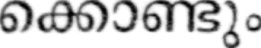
ക്കൊണ്ടും
